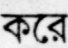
করে
